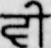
ਵੀ
